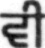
ਵੀ
